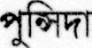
পুন্সিদা
